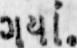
ગયાં.
